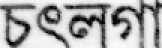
চৎলগা
